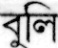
বুলি
